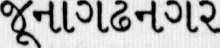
જૂનાગઢનગર
